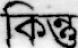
কিন্তু
